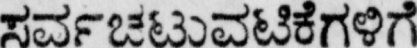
ಸರ್ವಚಟುವಟಿಕೆಗಳಿಗೆ
